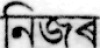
নিজৰ
